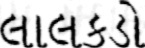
લાલકડો
